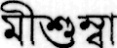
মীশুম্বা
